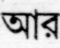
আর
